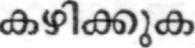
കഴിക്കുക
